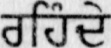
ਰਹਿੰਦੇ
